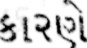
કારણે
